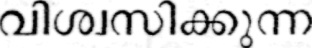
വിശ്വസിക്കുന്ന
